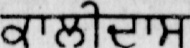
ਕਾਲੀਦਾਸ
